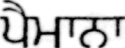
ਪੈਮਾਨਾ
